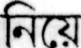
নিয়ে
